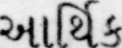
આર્થિક
